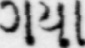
ગયા
